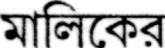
মালিকের
